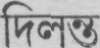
দিলন্ত
